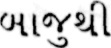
બાજુથી
